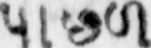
પાછળ
